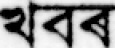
খবৰ
